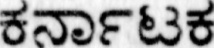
ಕರ್ನಾಟಕ
